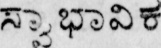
ಸ್ವಾಭಾವಿಕ
